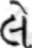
લે
